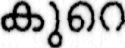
കുറെ
